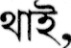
থাই,
